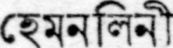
হেমনলিনী
